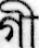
গী
